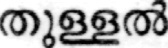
തുള്ളല്‍
